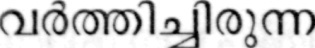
വര്‍ത്തിച്ചിരുന്ന
